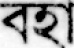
বহা
